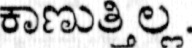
ಕಾಣುತ್ತಿಲ್ಲ.
